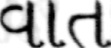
વાત
